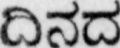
ದಿನದ
